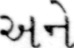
અને
